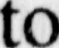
to
